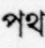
পথ
